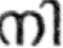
നി
